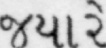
જ્યારે
